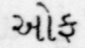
ઓફ
